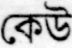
কেউ
